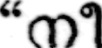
“നീ
